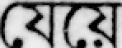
যেয়ে
